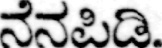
ನೆನಪಿಡಿ.
